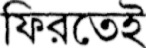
ফিরতেই
